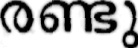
രണ്ടു
